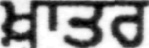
ਖ਼ਾਤਰ
